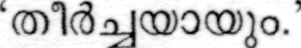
'തീര്‍ച്ചയായും.’
